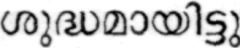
ശുദ്ധമായിട്ടു
